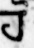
ਹੋ
